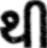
થી
